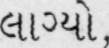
લાગ્યો,
